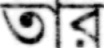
তার
